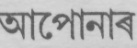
আপোনাৰ
